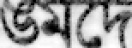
ঙমদে
